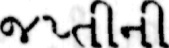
જપ્તીની
